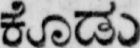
ಕೊಡು
